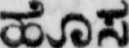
ಹೊಸ
